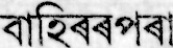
বাহিৰৰপৰা
